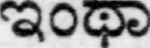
ಇಂಥಾ
